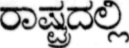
ರಾಷ್ಟ್ರದಲ್ಲಿ
